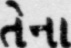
તેના
